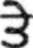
ਤੇ
